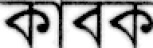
কাবক
